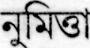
নুমিত্তা
